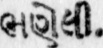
ભણેલી.
